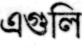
এগুলি
